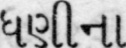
ધણીના
